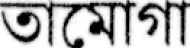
তামোগা
